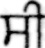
ਸੀ
